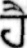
ਹੈ
